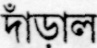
দাঁড়াল
